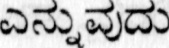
ಎನ್ನುವುದು
